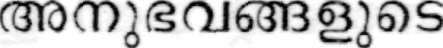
അനുഭവങ്ങളുടെ
